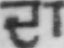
ਦਾ
